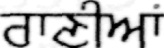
ਰਾਣੀਆਂ
